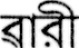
ৱারী
